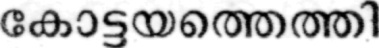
കോട്ടയത്തെത്തി
